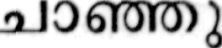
ചാഞ്ഞു
